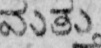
ಮತ್ತು
